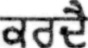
ਕਰਦੈ
